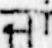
ਜਾਂ
